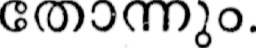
തോന്നും.
